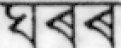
ঘৰৰ
